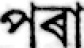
পৰা
